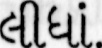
લીધાં.
